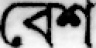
বেশ
